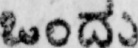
ಒಂದು
